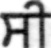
ਸੀ
